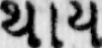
થાય
